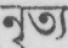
নৃত্য
